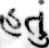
હતું
